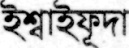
ইশ্বাইফূদা
